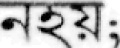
নহয়;
